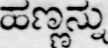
ಹಣ್ಣನ್ನು
